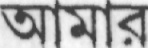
আমার
